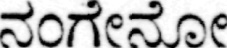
ನಂಗೇನೋ
